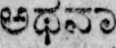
ಅಥವಾ
